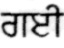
ਗਈ
